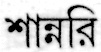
শান্নরি
